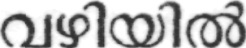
വഴിയില്‍
